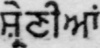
ਸ਼੍ਰੇਣੀਆਂ
